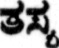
ತಸ್ಯ
